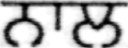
ਨਾਲ
